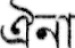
ঐনা
